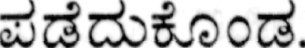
ಪಡೆದುಕೊಂಡ.
